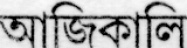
আজিকালি
